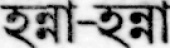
হন্না-হন্না
